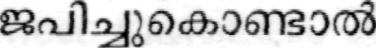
ജപിച്ചുകൊണ്ടാല്‍
